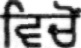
ਵਿਚੋਂ
